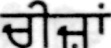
ਚੀਜ਼ਾਂ
